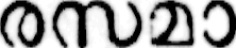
രസമാ
